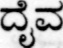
ದೈವ
